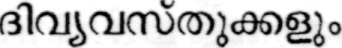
ദിവ്യവസ്തുക്കളും
